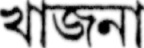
খাজনা
